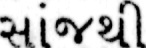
સાંજથી
